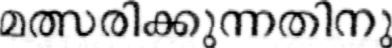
മത്സരിക്കുന്നതിനു
